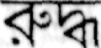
রুদ্ধ
